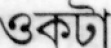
ওকটা
